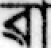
ৱা
